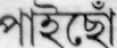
পাইছোঁ
